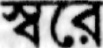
স্বরে
